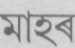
মাহৰ
